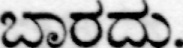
ಬಾರದು.
